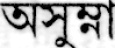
অসুম্না
